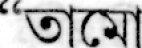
“তামো
